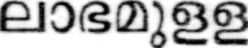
ലാഭമുളള
